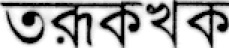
তরূকখক
